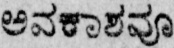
ಅವಕಾಶವೂ
